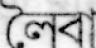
লৈবা
